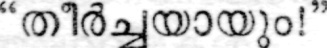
“തീര്‍ച്ചയായും!”
